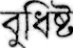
বুধিষ্ট
